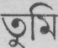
তুমি
